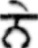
ਨੇ
